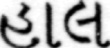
હાલ
